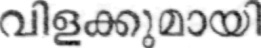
വിളക്കുമായി
